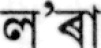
ল'ৰা
